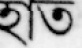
হাত
